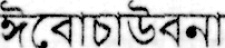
ঈবোচাউবনা
